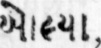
બોલ્યા,
